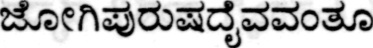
ಜೋಗಿಪುರುಷದೈವವಂತೂ
